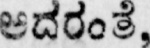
ಅದರಂತೆ,
